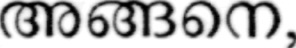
അങ്ങനെ,
